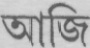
আজি
